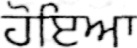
ਹੋਇਆ
